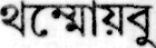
থম্মোয়বু
